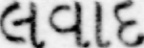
લવાદ
